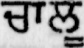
ਚਾਲੂ
